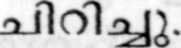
ചിറിച്ചു.
